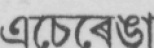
এচেৰেঙা
